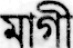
মাগী
